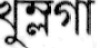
খুম্লগা
